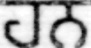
ਹਨ
